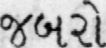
જબરો
